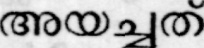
അയച്ചത്
